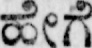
ಹೇಗೆ
